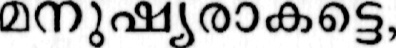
മനുഷ്യരാകട്ടെ,
